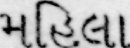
મહિલા
